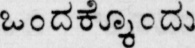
ಒಂದಕ್ಕೊಂದು
